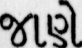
જાણે
